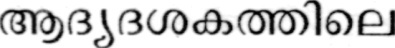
ആദ്യദശകത്തിലെ
